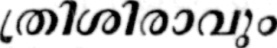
ത്രിശിരാവും
